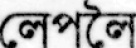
লেপলৈ
